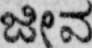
ಜೀವ
